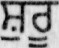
ਸ਼ੁਰੂ
